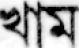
খাম
